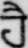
ਹੈ
